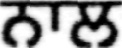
ਨਾਲ
